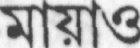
মায়াও
